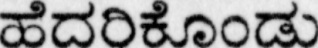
ಹೆದರಿಕೊಂಡು
